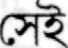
সেই
